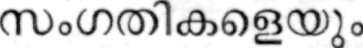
സംഗതികളെയും
